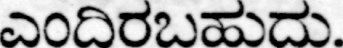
ಎಂದಿರಬಹುದು.
